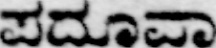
ಪದೂವಾ
